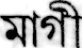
মাগী
